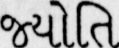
જ્યોતિ
